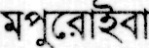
মপুরোইবা
